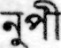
নুপী
